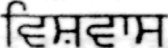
ਵਿਸ਼ਵਾਸ
